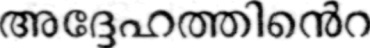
അദ്ദേഹത്തിന്റെ
